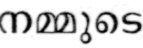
നമ്മുടെ
